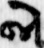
જો
